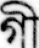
গী
